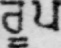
ਰੂਪ
